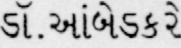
ડૉ.આંબેડકરે
